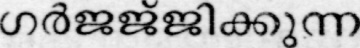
ഗര്‍ജജ്ജിക്കുന്ന
